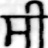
ਸੀ
